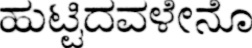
ಹುಟ್ಟಿದವಳೇನೊ
